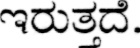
ಇರುತ್ತದೆ.
